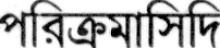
পরিক্রমাসিদি
